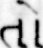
તો
